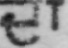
ਦਾ
